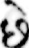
છે
